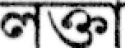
লক্তা
